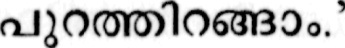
പുറത്തിറങ്ങാം.’
